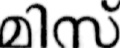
മിസ്
